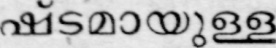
ഷ്ടമായുള്ള
